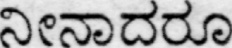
ನೀನಾದರೂ
